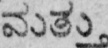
ಮತ್ತು
